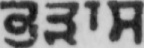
ਭੜਾਸ
